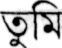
তুমি
